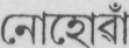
নোহোৱাঁ
